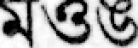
মওঙ
